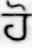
ਹੋ
